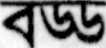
বড্ড
